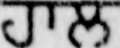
ਹਾਲ
